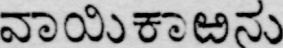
ವಾಯಿಕಾಱನು
